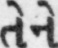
તેને
